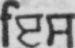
ਇਸ
